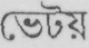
ভেটয়
